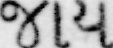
જાય
